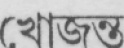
খোজন্ত
